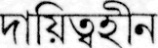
দায়িত্বহীন
